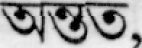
অন্তত,
